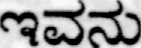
ಇವನು
